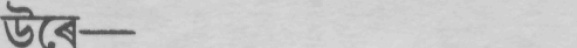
উৰে-
